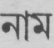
নাম
